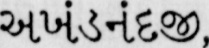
અખંડનંદજી,
